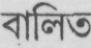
বালিত
